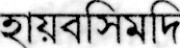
হায়বসিমদি
